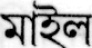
মাইল
